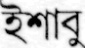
ইশাবু
